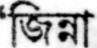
‘জিন্না
